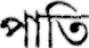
পাতি
